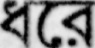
ধরে
